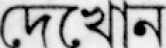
দেখোন
